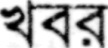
খবর
